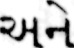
અને
